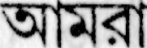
আমরা
